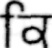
ਕਿ
